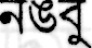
নঙবু
